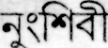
নুংশিবী
